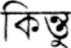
কিন্তু
